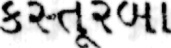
કસ્તૂરબા
